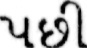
પછી
